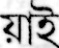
য়াই
